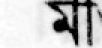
মা
